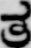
ತ
